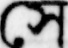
সে
